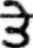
ਤੇ
